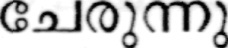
ചേരുന്നു
